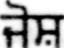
ਜੋਸ਼
